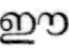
ഈ
